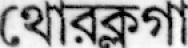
থোরক্লগা
